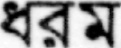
ধরম
